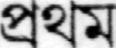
প্রথম
